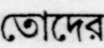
তোদের
